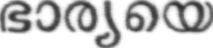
ഭാര്യയെ
